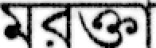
মরক্তা
